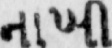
નાખી
